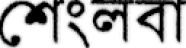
শেংলবা
